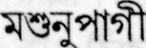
মশুনুপাগী
